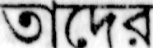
তাদের
